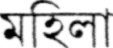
মহিলা
